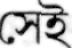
সেই
